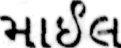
માઈલ
